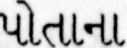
પોતાના
